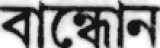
বান্ধোন
